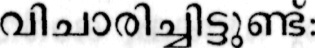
വിചാരിച്ചിട്ടുണ്ട്:
